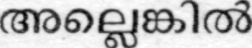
അല്ലെങ്കില്‍
